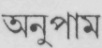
অনুপাম
